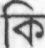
কি
